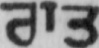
ਰਾਤ
